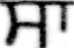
ਸਾਂ
